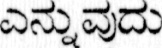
ಎನ್ನುವುದು
